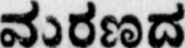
ಮರಣದ
